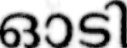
ഓടി
